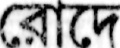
রোদে
